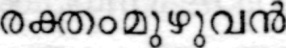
രക്തംമുഴുവന്‍
